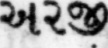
અરજી
